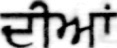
ਦੀਆਂ
